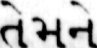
તેમને
